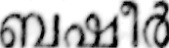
ബഷീര്‍
